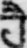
ਹੈ
